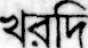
খরদি
